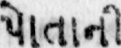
પોતાની
